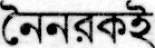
নৈনরকই
